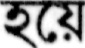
হয়ে
